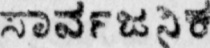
ಸಾರ್ವಜನಿಕ
